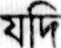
যদি
